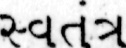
સ્વતંત્ર
